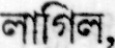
লাগিল,
